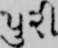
પુરી
